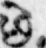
છે.
